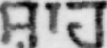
ਸ਼ਾਹ
